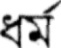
ধর্ম
